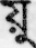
য়ু
